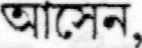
আসেন,
